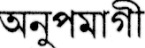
অনুপমাগী
